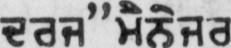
ਦਰਜ''ਮੈਨੇਜਰ
